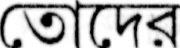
তোদের
